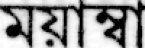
ময়াম্বা
